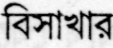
বিসাখার
